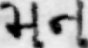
મન
